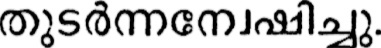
തുടര്‍ന്നന്വേഷിച്ചു.
